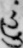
હું
